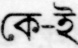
কে-ই
